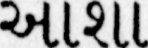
આશા
